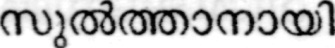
സുല്‍ത്താനായി
